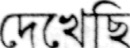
দেখেছি
